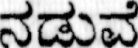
ನಡುವೆ
